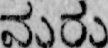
ಮರು
